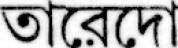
তারেদো
